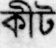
কীট
